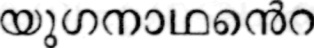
യുഗനാഥന്റെ
